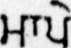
ਮਾਪੇ
